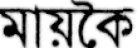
মায়কৈ
